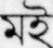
মই
